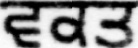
ਵਕਤ
